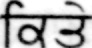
ਕਿਤੇ
